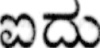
ಐದು
